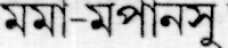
মমা-মপানসু
